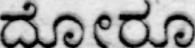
ದೋರೊ
